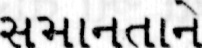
સમાનતાને
